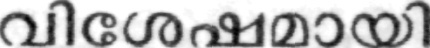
വിശേഷമായി
